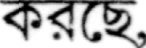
করছে,
